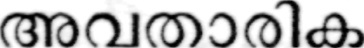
അവതാരിക
